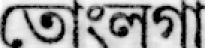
তোংলগা
